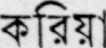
করিয়া
